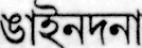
ঙাইনদনা
